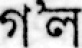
গ'ল
